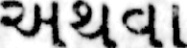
અથવા
